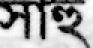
সাহু
